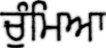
ਚੁੰਮਿਆ
